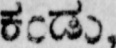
ಕಂಡು,
